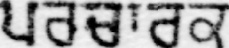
ਪਰਚਾਰਕ
